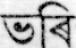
ভৰি
